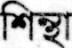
শিন্থা
